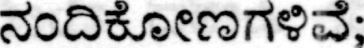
ನಂದಿಕೋಣಗಳಿವೆ;
